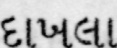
દાખલા
